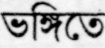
ভঙ্গিতে
